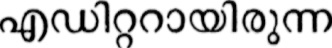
എഡിറ്ററായിരുന്ന
